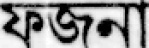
ফজনা
